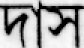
দাস
